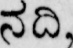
ನದಿ,
